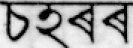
চহৰৰ
